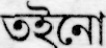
তইনো
